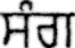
ਸੰਗ
